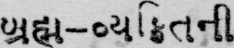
બ્રહ્મ-વ્યક્તિની
